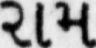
રામ
